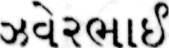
ઝવેરભાઈ
